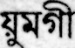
য়ুমগী
